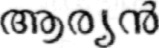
ആര്യന്‍
